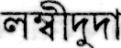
লম্বীদুদা
